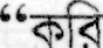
“করি
